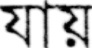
যায়
